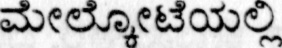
ಮೇಲ್ಕೋಟೆಯಲ್ಲಿ
